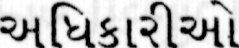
અધિકારીઓ
